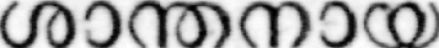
ശാന്തനായ
